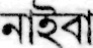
নাইবা
